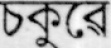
চকুৱে
